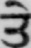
ਤੇ
